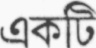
একটি
